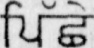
ਪਿੱਛੇ
